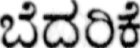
ಬೆದರಿಕೆ
